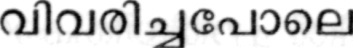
വിവരിച്ചപോലെ
